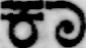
ಕಾ
